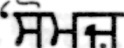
'ਸੋਮਜ਼
